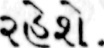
રહેશે.
